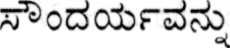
ಸೌಂದರ್ಯವನ್ನು
